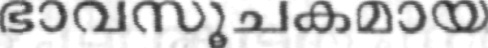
ഭാവസൂചകമായ
